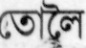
তোলৈ
